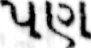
પણ
